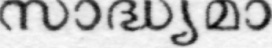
സാദ്ധ്യമാ
